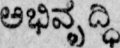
ಅಭಿವೃದ್ಧಿ
